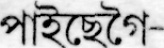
পাইছেগৈ-
